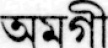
অমগী
